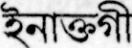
ইনাক্তগী
